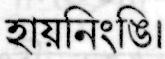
হায়নিংঙি।
